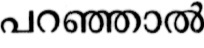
പറഞ്ഞാല്‍
